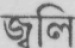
জ্বলি
